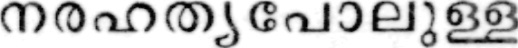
നരഹത്യപോലുള്ള
